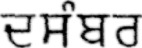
ਦਸੰਬਰ
